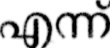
എന്ന്
